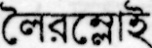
লৈরম্লোই
